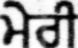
ਮੇਰੀ
